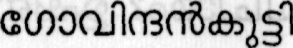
ഗോവിന്ദന്‍കുട്ടി
